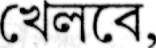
খেলবে,
